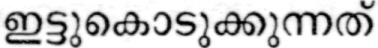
ഇട്ടുകൊടുക്കുന്നത്
